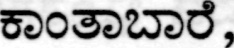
ಕಾಂತಾಬಾರೆ,
